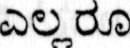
ಎಲ್ಲರೂ
